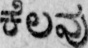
ಕೆಲವು
